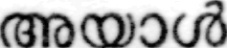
അയാള്‍
